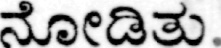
ನೋಡಿತು.
